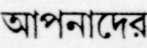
আপনাদের
